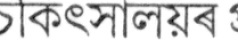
চিকিৎসালয়ৰ
